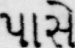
પાસે
